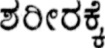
ಶರೀರಕ್ಕೆ
